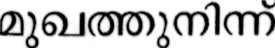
മുഖത്തുനിന്ന്
